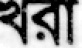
খরা
